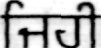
ਜਿਹੀ
